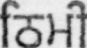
ਠਿਮੀ
